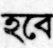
হবে
